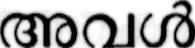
അവള്‍
